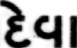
દેવા
